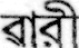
ৱারী
